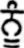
ਨੂੰ
